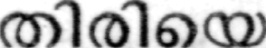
തിരിയെ
